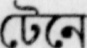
টেনে
